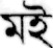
মই
